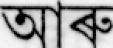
আৰু
